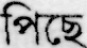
পিছে
